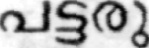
പട്ടരു
